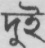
দুই
